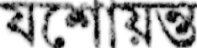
যশোয়ন্ত
